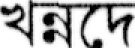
খন্নদে
